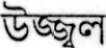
উজ্বল
